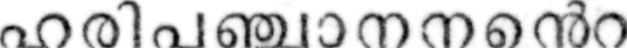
ഹരിപഞ്ചാനനന്റെ
